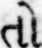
તો
